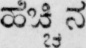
ಹೆಚ್ಚಿನ
